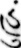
હું
